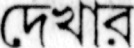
দেখার
